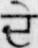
ਦੇ
